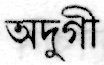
অদুগী
